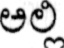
ಅಲ್ಲಿ
